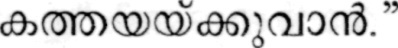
കത്തയയ്ക്കുവാന്‍."
